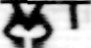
ਲਾ
